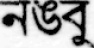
নঙবু
